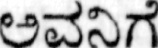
ಅವನಿಗೆ
